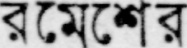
রমেশের
